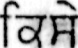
ਕਿਸੇ
